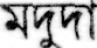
মদুদা
